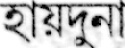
হায়দুনা
